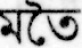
মতৈ
